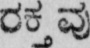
ರಕ್ತವು
